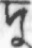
দু
